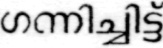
ഗന്നിച്ചിട്ട്
